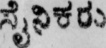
ಸೈನಿಕರು
